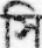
সি
